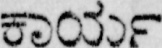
ಕಾರ್ಯ
